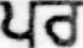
ਪਰ
